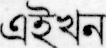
এইখন
